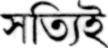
সত্যিই
